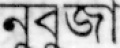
নুবুজা
